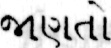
જાણતો
